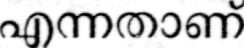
എന്നതാണ്
